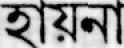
হায়না
